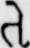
તે
